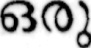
ഒരു
